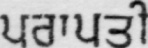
ਪਰਾਪਤੀ
